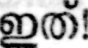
ഇത്!
